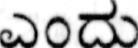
ಎಂದು
